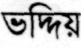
ভদ্দিয়
